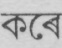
কৰে
